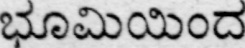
ಭೂಮಿಯಿಂದ
